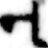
ન
